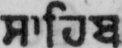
ਸਾਹਿਬ
